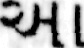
આ
